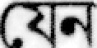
যেন
